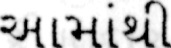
આમાંથી
